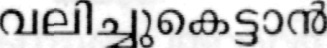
വലിച്ചുകെട്ടാന്‍
